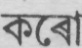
কৰো
